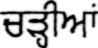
ਚੜ੍ਹੀਆਂ
